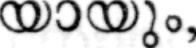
യായും,
